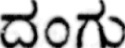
ದಂಗು
